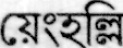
য়েংহল্লি
